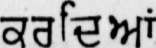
ਕਰਦਿਆਂ
